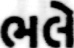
ભલે
